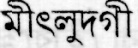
মীৎলুদগী
